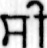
ਸੀ
